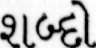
શબ્દો
